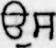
ਉਸ
